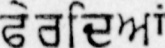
ਫੇਰਦਿਆਂ
